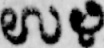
ಉಳಿ
